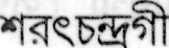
শরৎচন্দ্রগী
